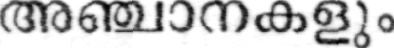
അഞ്ചാനകളും
